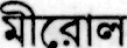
মীরোল
